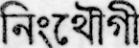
নিংথৌগী
